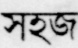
সহজ
